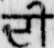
ਦੀ
